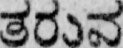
ತರುವ
